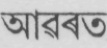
আৱৰত
